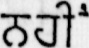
ਨਹੀਂ
